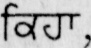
ਕਿਹਾ,
